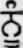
ਨੂੰ
